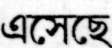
এসেছে
